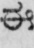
ಈ
